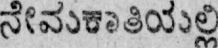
ನೇಮಕಾತಿಯಲ್ಲಿ
